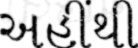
અહીંથી
